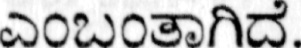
ಎಂಬಂತಾಗಿದೆ.
